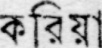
করিয়া
